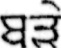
ਬੜੇ
